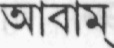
আবাম্
